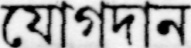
যোগদান
